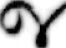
જ
